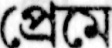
প্রেমে
